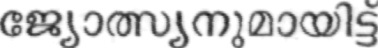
ജ്യോത്സ്യനുമായിട്ട്
